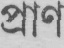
প্ৰাণ
